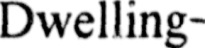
Dwelling-
